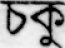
চকু
